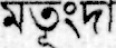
মতূংদা
